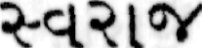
સ્વરાજ
